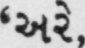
'અરે,
